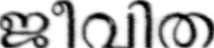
ജീവിത
